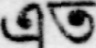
এত
